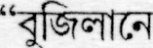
"বুজিলানে
